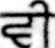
ਵੀ
